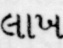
લાખ
